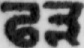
ਫੜ
